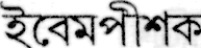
ইবেমপীশক
